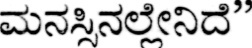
ಮನಸ್ಸಿನಲ್ಲೇನಿದೆ"
